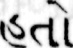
હતો
